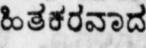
ಹಿತಕರವಾದ
